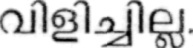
വിളിച്ചില്ല.
